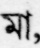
মা,
